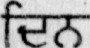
ਦਿਨ
